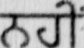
ਨਹੀਂ
